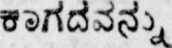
ಕಾಗದವನ್ನು
